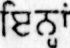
ਇਨ੍ਹਾਂ
